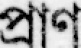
প্রাণ
